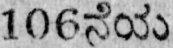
106ನೆಯ
